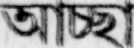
আচ্ছা
